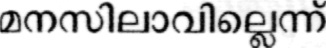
മനസിലാവില്ലെന്ന്
